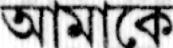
আমাকে
